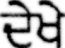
ਦੇਖੇ
